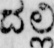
ದಲ್ಲಿ
